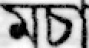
মচা
